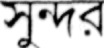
সুন্দর
